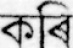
কৰি
